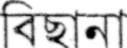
বিছানা
